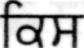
ਕਿਸ
